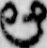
ಆ
